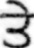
ਤੇ
